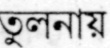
তুলনায়
